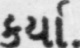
કર્યા.
